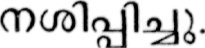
നശിപ്പിച്ചു.
